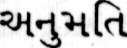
અનુમતિ
